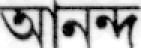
আনন্দ
